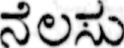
ನೆಲಸು
